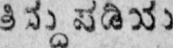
ತಿದ್ದುಪಡಿಯ
